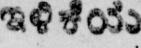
ಇಳಿಕೆಯ
